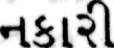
નકારી
